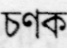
চণক
